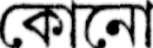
কোনো
